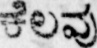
ಕೆಲವು
